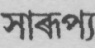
সাৰূপ্য
